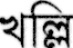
খল্লি
